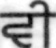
ਵੀ
